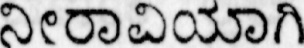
ನೀರಾವಿಯಾಗಿ
